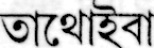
তাথোইবা
